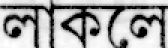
লাকলে
